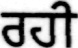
ਰਹੀ
